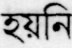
হয়নি
